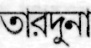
তারদুনা
